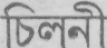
চিলনী
